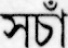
সচাঁ
